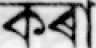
কৰা
